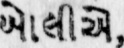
બોલીએ,
